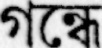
গন্ধে
